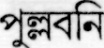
পুল্লবনি
